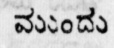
ಮುಂದು
